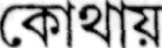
কোথায়
